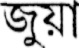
জুয়া
